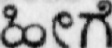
ಹೀಗೆ
